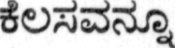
ಕೆಲಸವನ್ನೂ
